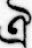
ঐ
